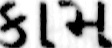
કામ
